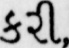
કરી,
